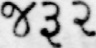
જરૂર
